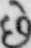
છે
